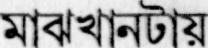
মাঝখানটায়
